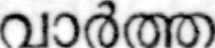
വാര്‍ത്ത
